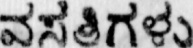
ವಸತಿಗಳು
